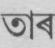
তাৰ
